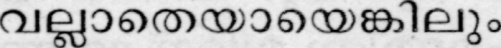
വല്ലാതെയായെങ്കിലും
